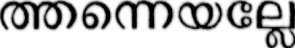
ത്തന്നെയല്ലേ
